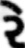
રે
